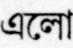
এলো
